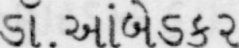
ડૉ.આંબેડકર
